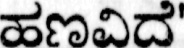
ಹಣವಿದೆ'
